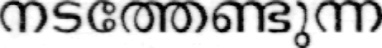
നടത്തേണ്ടുന്ന
